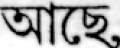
আছে,
